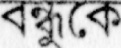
বন্ধুকে
